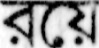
রয়ে
